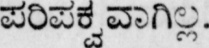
ಪರಿಪಕ್ವವಾಗಿಲ್ಲ.
